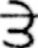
ਤੇ
